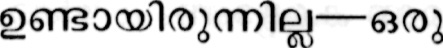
ഉണ്ടായിരുന്നില്ല-ഒരു
